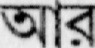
আর
